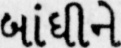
બાંધીને
